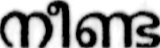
നീണ്ട
